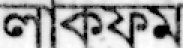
লাকফম
